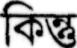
কিন্তু
